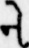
ને
